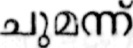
ചുമന്ന്
